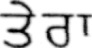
ਤੇਰਾ
